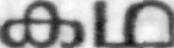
കഥ
